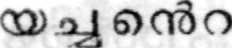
യച്ചന്റെ
